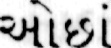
ઓછાં
